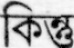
কিন্তু
